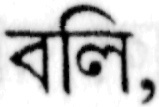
বলি,
